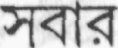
সবার
